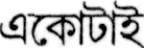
একোটাই
